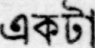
একটা
